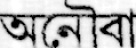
অনৌবা
